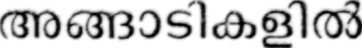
അങ്ങാടികളില്‍
